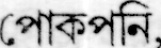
পোকপনি,
